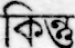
কিন্তু
